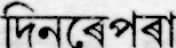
দিনৰেপৰা
